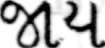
જાય
